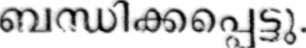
ബന്ധിക്കപ്പെട്ടു.
